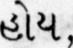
હોય,
